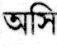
অসি
